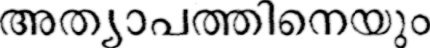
അത്യാപത്തിനെയും
